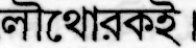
লৌথোরকই
